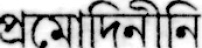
প্রমোদিনীনি
